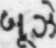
બૂઝે
